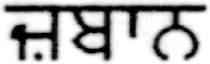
ਜ਼ਬਾਨ
